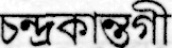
চন্দ্রকান্তগী
